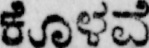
ಕೊಳವೆ
